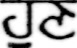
ਹੁਣ
